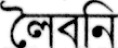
লৈবনি
